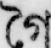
গৈ
